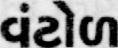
વંટોળ
